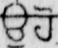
ਉਹੋ
